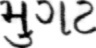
મુગટ
